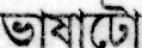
ভাষাটো
